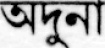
অদুনা
